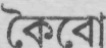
কৈবো
